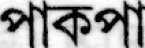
পাকপা
